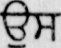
ਉਸ
